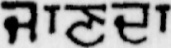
ਜਾਣਦਾ
